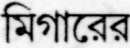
মিগারের
